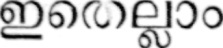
ഇതെല്ലാം
